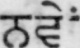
ਨਵੇਂ
